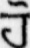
ਹੋ
